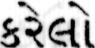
કરેલો
